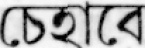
চেহাবে
